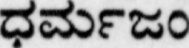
ಧರ್ಮಜಂ
